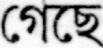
গেছে
